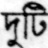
দুটি
